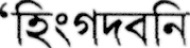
‘হিংগদবনি
